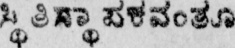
ಸ್ಥಿತಿಸ್ಥಾಪಕವಂತೂ
